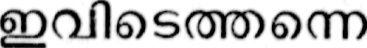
ഇവിടെത്തന്നെ
